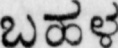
ಬಹಳ
